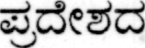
ಪ್ರದೇಶದ
